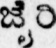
ಜೈರಿ
